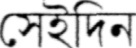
সেইদিন
